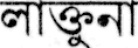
লাক্তুনা
